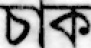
চাক
